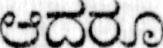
ಆದರೂ
